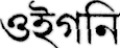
ওইগনি
